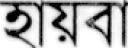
হায়বা
